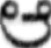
ಆ
